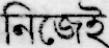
নিজেই
